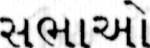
સભાઓ
